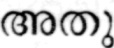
അതു
